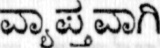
ವ್ಯಾಪ್ತವಾಗಿ
